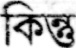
কিন্তু
